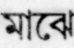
মাঝে
